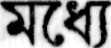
মধ্যে
